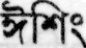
ঈশিং
